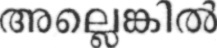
അല്ലെങ്കില്‍
